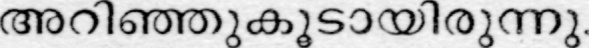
അറിഞ്ഞുകൂടായിരുന്നു.
